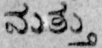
ಮತ್ತು
